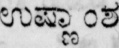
ಉಷ್ಣಾಂಶ
